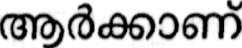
ആര്‍ക്കാണ്
